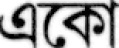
একো
